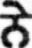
ਨੇ
